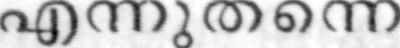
എന്നുതന്നെ
